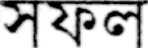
সফল
